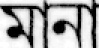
মানা
